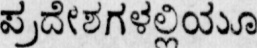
ಪ್ರದೇಶಗಳಲ್ಲಿಯೂ
